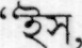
"ইস,
